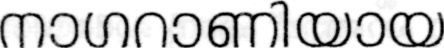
നാഗറാണിയായ
